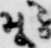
મૂકે
